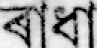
ৰাধা
